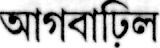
আগবাঢ়িল
